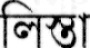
লিস্তা
